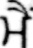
ਮੈਂ
